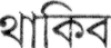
থাকিব
